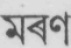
মৰণ
